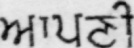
ਆਪਣੀ
